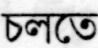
চলতে
